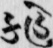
કહે
